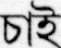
চাই
